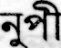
নুপী
